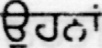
ਉਹਨਾਂ
